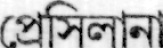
প্রেসিলানা
